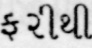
ફરીથી
